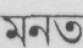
মনত
